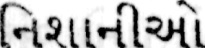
નિશાનીઓ
